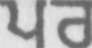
ਪਰ
